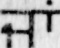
ਜਾਂ
